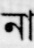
না
